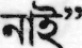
নাই"
